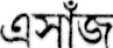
এসাঁজ
